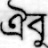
ঐবু
